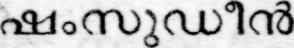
ഷംസുഡീന്‍
